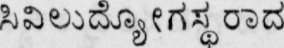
ಸಿವಿಲುದ್ಯೋಗಸ್ಥರಾದ
